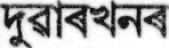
দুৱাৰখনৰ
